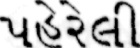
પહેરેલી
